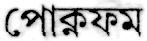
পোক্নফম
